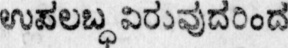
ಉಪಲಬ್ಧವಿರುವುದರಿಂದ
